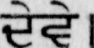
ਦੇਵੇ।
